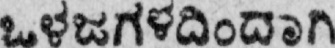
ಒಳಜಗಳದಿಂದಾಗಿ
